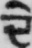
ਦੇ
